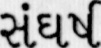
સંધર્ષ
